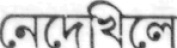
নেদেখিলে
